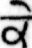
ਕੇ
